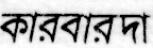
কারবারদা
